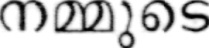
നമ്മുടെ
